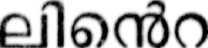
ലിന്റെ
